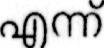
എന്ന്
